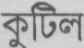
কুটিল
